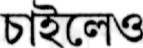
চাইলেও
